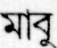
মাবু
